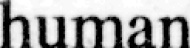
human
